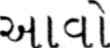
આવો
